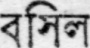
বসিল
